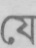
যে
